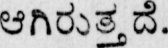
ಆಗಿರುತ್ತದೆ.
